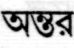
অন্তর
